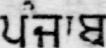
ਪੰਜਾਬ
